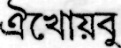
ঐখোয়বু
